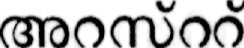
അറസ്ററ്
